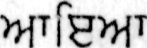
ਆਇਆ
